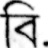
বি.
